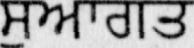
ਸੁਆਗਤ
